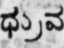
ಧ್ರುವ
